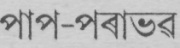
পাপ-পৰাভৱ
